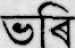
ভৰি
